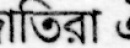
জাতিরা
